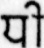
ਧੀ
